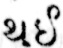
થઈ
